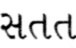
સતત
